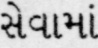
સેવામાં
